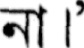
না।'
